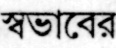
স্বভাবের
